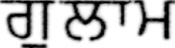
ਗੁਲਾਮ
